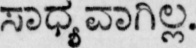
ಸಾಧ್ಯವಾಗಿಲ್ಲ.
